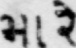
મારે
